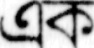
এক
